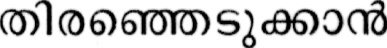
തിരഞ്ഞെടുക്കാന്‍
